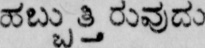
ಹಬ್ಬುತ್ತಿರುವುದು
